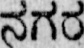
ನಗರ
